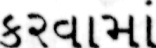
કરવામાં
